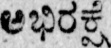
ಅಭಿರಕ್ಷೆ
